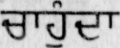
ਚਾਹੁੰਦਾ
